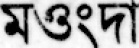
মওংদা
